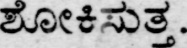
ಶೋಕಿಸುತ್ತ.
